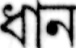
ধান
